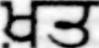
ਖ਼ਤ
